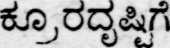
ಕ್ರೂರದೃಷ್ಟಿಗೆ
